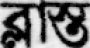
ব্লাস্ত
